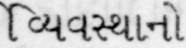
વ્યિવસ્થાનો
